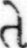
તે
